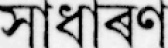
সাধাৰণ
